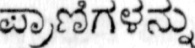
ಪ್ರಾಣಿಗಳನ್ನು
